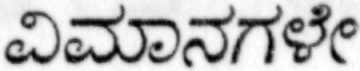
ವಿಮಾನಗಳೇ
